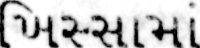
ખિસ્સામાં
